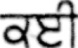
ਕਈ
